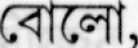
বোলো,
